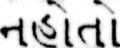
નહોતો
